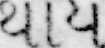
થાય
